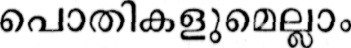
പൊതികളുമെല്ലാം
